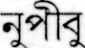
নুপীবু
